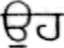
ਉਹ
